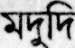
মদুদি
